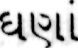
ઘણાં
